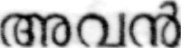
അവന്‍
